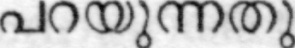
പറയുന്നതു
